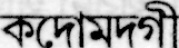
কদোমদগী
